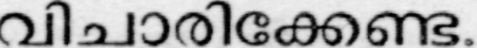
വിചാരിക്കേണ്ട.
